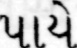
પાયે
